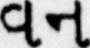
વન
